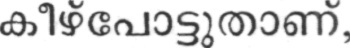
കീഴ്പോട്ടുതാണ്,
